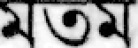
মতম
